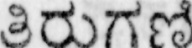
ತಿರುಗಣಿ
